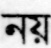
নয়
